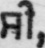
ਸੀ,
